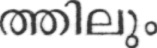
ത്തിലും
